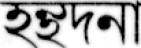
হন্থদনা
